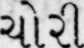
ચોરી
